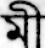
মী
